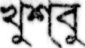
খুশ্বু
